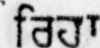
ਰਿਹਾ
